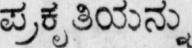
ಪ್ರಕೃತಿಯನ್ನು
